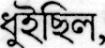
ধুইছিল,
